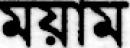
ময়াম
